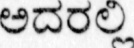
ಅದರಲ್ಲಿ
